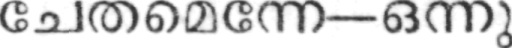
ചേതമെന്നേ-ഒന്നു
